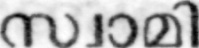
സ്വാമി
